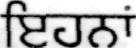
ਇਹਨਾਂ
